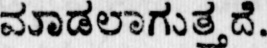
ಮಾಡಲಾಗುತ್ತದೆ.
